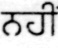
ਨਹੀਂ
